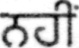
ਨਹੀਂ
